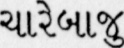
ચારેબાજુ
